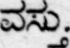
ವಸ್ತು.
